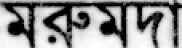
মরুমদা
